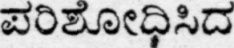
ಪರಿಶೋಧಿಸಿದ
